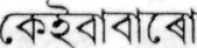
কেইবাবাৰো
